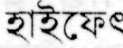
হাইফেৎ
